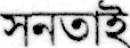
সনতাই
